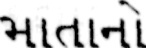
માતાનો
